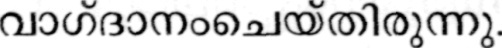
വാഗ്ദാനംചെയ്തിരുന്നു.
